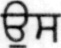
ਉਸ
